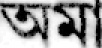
অমা
